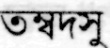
তম্বদসু
